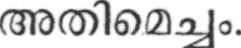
അതിമെച്ചം.
